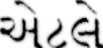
એટલે
